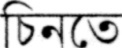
চিনতে
